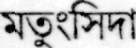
মতুংসিদা
